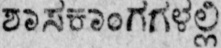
ಶಾಸಕಾಂಗಗಳಲ್ಲಿ
